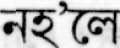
নহ'লে
